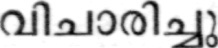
വിചാരിച്ചു
